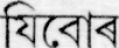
যিবোৰ
